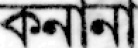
কনানা
